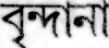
বৃন্দানা
